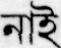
নাই
